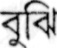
বুঝি
